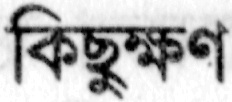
কিছুক্ষণ
